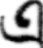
এ
